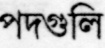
পদগুলি
